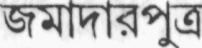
জমাদারপুত্র
